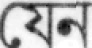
যেন
